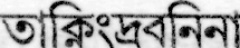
তাক্নিংদ্রবনিনা
